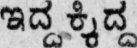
ಇದ್ದಕ್ಕಿದ್ದ
